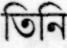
তিনি
